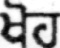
ਖੋਹ
